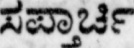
ಸಪ್ತಾರ್ಚಿ
